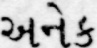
અનેક
